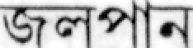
জলপান
